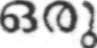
ഒരു
